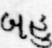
બહુ
